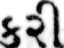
કરી
